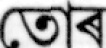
তোৰ
